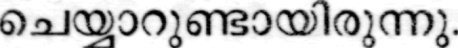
ചെയ്യാറുണ്ടായിരുന്നു.
